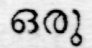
ഒരു
